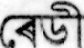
ৰেডী
